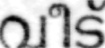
വീട്
